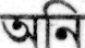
অনি
